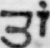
ਤਾਂ
